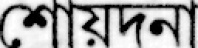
শোয়দনা
